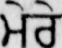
ਮੇਰੇ
